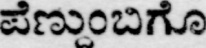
ಪೆಣ್ದುಂಬಿಗೊ
